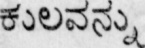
ಕುಲವನ್ನು
